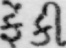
ફેંકી
